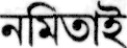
নমিতাই
